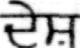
ਦੇਸ਼
